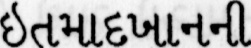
ઇતમાદખાનની
